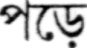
পড়ে
